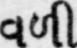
વળી
